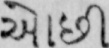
ઓછી
